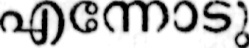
എന്നോടു
